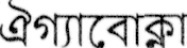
ঐগ্যাবোক্না
